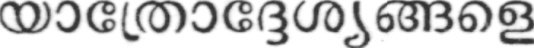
യാത്രോദ്ദേശ്യങ്ങളെ
